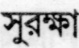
সুরক্ষা
